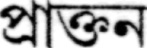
প্রাক্তন
